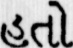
હતો
